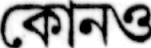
কোনও
